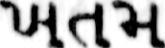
ખતમ
